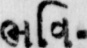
ભવિ-
